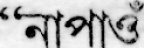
"নাপাওঁ
